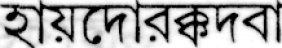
হায়দোরক্কদবা
